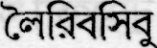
লৈরিবসিবু
